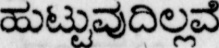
ಹುಟ್ಟುವುದಿಲ್ಲವೆ
